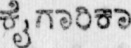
ಕೈಗಾರಿಕಾ
